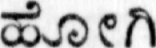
ಹೋಗಿ
